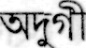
অদুগী
